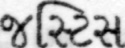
જસ્ટિસ
